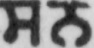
ਸਨ
